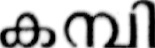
കമ്പി
